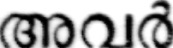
അവര്‍
